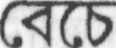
বেচে
